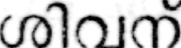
ശിവന്
